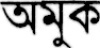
অমুক
